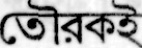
তৌরকই
